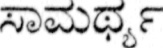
ಸಾಮರ್ಥ್ಯ
